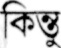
কিন্তু
